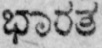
ಭಾರತ
